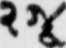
રજૂ
